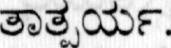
ತಾತ್ಪರ್ಯ.
